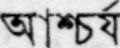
আশ্চর্য
